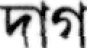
দাগ
